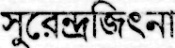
সুরেন্দ্রজিৎনা
